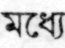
মধ্যে
